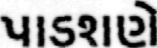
પાડશણે
